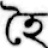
হৈ
